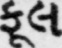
ફૂલ
